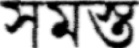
সমস্ত
